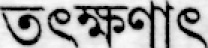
তৎক্ষণাৎ
